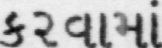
કરવામાં
